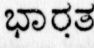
ಭಾರತ
